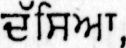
ਦੱਸਿਆ,
